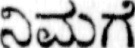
ನಿಮಗೆ
